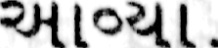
આવ્યા.
